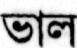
ভাল
